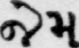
જેમ
